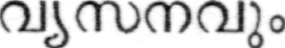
വ്യസനവും
